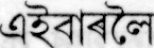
এইবাৰলৈ
